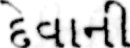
દેવાની
